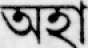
অহা
